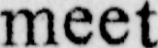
meet
